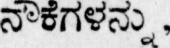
ನೌಕೆಗಳನ್ನು,
